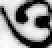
ও
